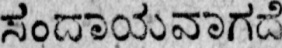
ಸಂದಾಯವಾಗದೆ
